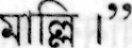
মাল্লি।”
